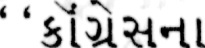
"કૉંગ્રેસના
